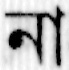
না
